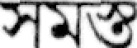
সমস্ত
